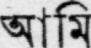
আমি
